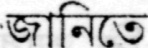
জানিতে
